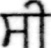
ਸੀ
